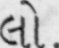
લો.
